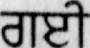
ਗਈ
